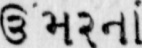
ઉંમરનાં
